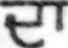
ਦਾ
